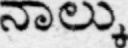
ನಾಲ್ಕು
